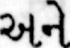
અને
